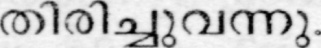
തിരിച്ചുവന്നു.
